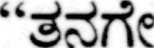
"ತನಗೇ
